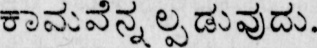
ಕಾಮವೆನ್ನಲ್ಪಡುವುದು.
